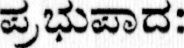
ಪ್ರಭುಪಾದ:
